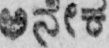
ಅನೇಕ
